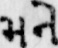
મને
